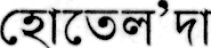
হোতেল’দা
